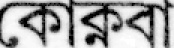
কোক্নবা
